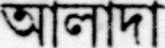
আলাদা
